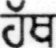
ਹੱਥ
